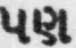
પણ
